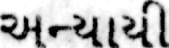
અન્યાયી
